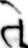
તે
